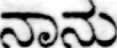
ನಾನು
